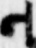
ન
